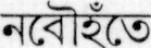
নবৌহঁতে
